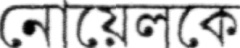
নোয়েলকে
